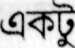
একটু
